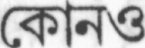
কোনও
